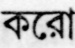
করো
